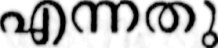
എന്നതു
